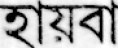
হায়বা
